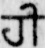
ਹੀ
